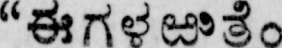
“ಈಗಳಱಿತೆಂ
